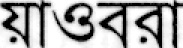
য়াওবরা
